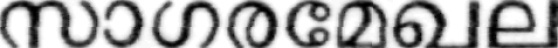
സാഗരമേഖല
